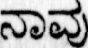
ನಾವು
